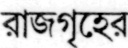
রাজগৃহের
